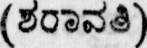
(ಶರಾವತಿ)
